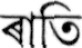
ৰাতি
